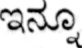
ಇನ್ನೂ
